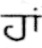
ਹਾਂ
